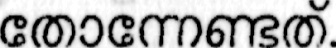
തോന്നേണ്ടത്.
